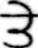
ਤੇ
